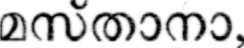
മസ്താനാ,
